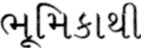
ભૂમિકાથી
